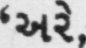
'અરે,
